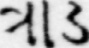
ત્રાડ
